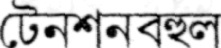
টেনশনবহুল
